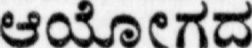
ಆಯೋಗದ
